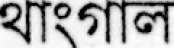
থাংগাল
